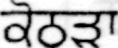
ਕੋਠੜਾ
